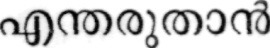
എന്തരുതാന്‍
